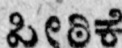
ಪೀಠಿಕೆ
